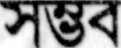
সম্ভব
